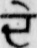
ਦੇ
